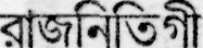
রাজনিতিগী
